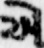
એ
